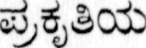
ಪ್ರಕೃತಿಯ
